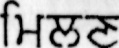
ਮਿਲਣ
